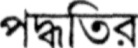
পদ্ধতির
